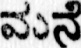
ಮನೆ
